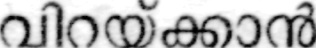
വിറയ്ക്കാന്‍
